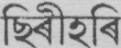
ছিৰীহৰি
